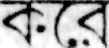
করে
